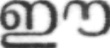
ഈ
